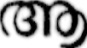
ആ
